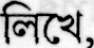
লিখে,
